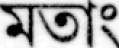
মতাং
